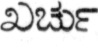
ಖರ್ಚು
